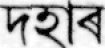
দহাৰ
